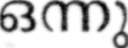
ഒന്നു
